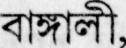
বাঙ্গালী,
